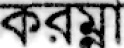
করম্না
